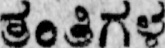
ತಂತಿಗಳ
